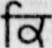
ਕਿ
